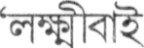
'লক্ষ্মীবাই
